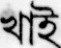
খাই
